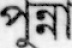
পুন্না
